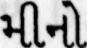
મીનો
